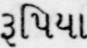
રૂપિયા
